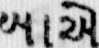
બાએ
